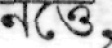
নত্তে,
